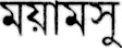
ময়ামসু
